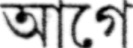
আগে
